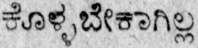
ಕೊಳ್ಳಬೇಕಾಗಿಲ್ಲ
